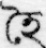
হৈ
